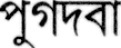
পুগদবা
